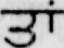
ਤਾਂ
